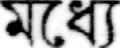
মধ্যে
